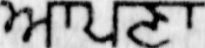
ਆਪਣਾ
